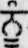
ਨੂੰ
